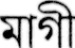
মাগী
